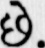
છે.
